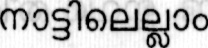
നാട്ടിലെല്ലാം
